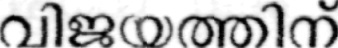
വിജയത്തിന്
